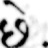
છે.
